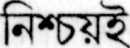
নিশ্চয়ই
